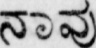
ನಾವು
